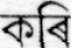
কৰি
